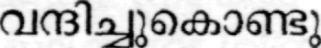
വന്ദിച്ചുകൊണ്ടു
